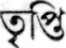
তৃপ্তি
